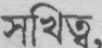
সখিত্ব,
